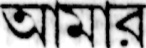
আমার
